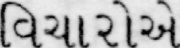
વિચારોએ
